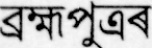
ব্রহ্মপুত্রৰ
